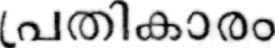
പ്രതികാരം
